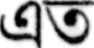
এত
